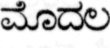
ಮೊದಲ
